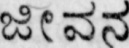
ಜೀವನ
